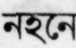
নহনে
